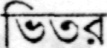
ভিতর
